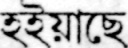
হইয়াছে
